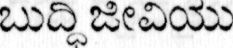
ಬುದ್ಧಿಜೀವಿಯು
